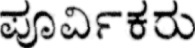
ಪೂರ್ವಿಕರು
